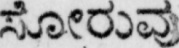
ಸೋರುವು
